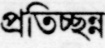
প্রতিচ্ছন্ন
